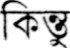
কিন্তু
